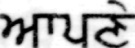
ਆਪਣੇ
